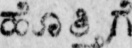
ಹೊತ್ತಿಗೆ
